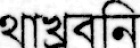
থাখ্রবনি
